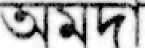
অমদা
